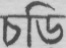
চড়ি
